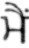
ਮੈਂ
